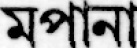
মপানা
